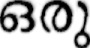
ഒരു
